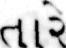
તારે
